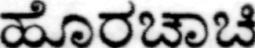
ಹೊರಚಾಚಿ
